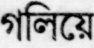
গলিয়ে
